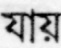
যায়
